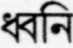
ধ্বনি
